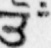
ਤੋਂ
